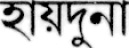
হায়দুনা
